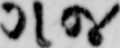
ગજ
